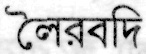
লৈরবদি
